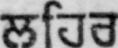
ਲਹਿਰ
